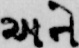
અને
